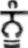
ਨੂੰ
